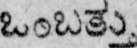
ಒಂಬತ್ತು
